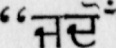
''ਜਦੋਂ
